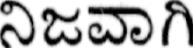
ನಿಜವಾಗಿ
